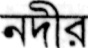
নদীর
